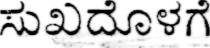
ಸುಖದೊಳಗೆ
